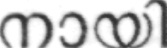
നായി
